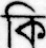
কি
